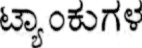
ಟ್ಯಾಂಕುಗಳ
